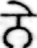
ਨੇ
